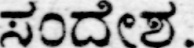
ಸಂದೇಶ.
